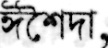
ঈশৈদা,
